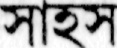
সাহস
